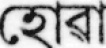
হোৱা
